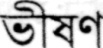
ভীষণ
